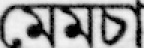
মেমচা
